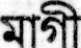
মাগী
